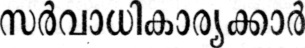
സര്‍വാധികാര്യക്കാര്‍
